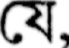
যে,
